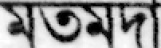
মতমদা
